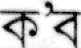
ক'ব
